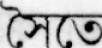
সৈতে
